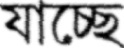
যাচ্ছে
